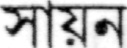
সায়ন
